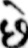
છે
